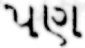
પણ
